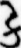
કે
